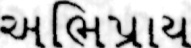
અભિપ્રાય
